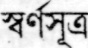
স্বর্ণসূত্র
